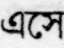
এসে
